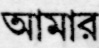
আমার
